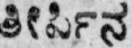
ತೀರ್ಪಿನ
